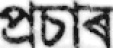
প্রচাৰ
